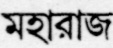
মহারাজ
